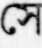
সে
